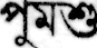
পুমশু
